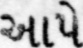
આપે
